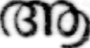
ആ
